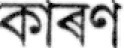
কাৰণ
